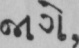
જાગે,
